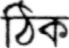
ঠিক
